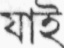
যাই
